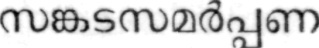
സങ്കടസമര്‍പ്പണ
